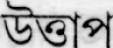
উত্তাপ
